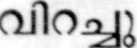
വിറച്ചു
